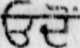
ਓਦੋਂ
